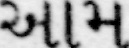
આમ
